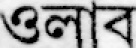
ওলাব
